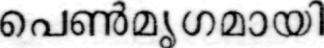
പെണ്‍മൃഗമായി
